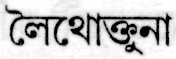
লৈথোক্তুনা
